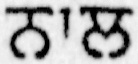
ਨਾਲ
